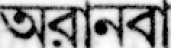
অরানবা
